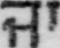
ਜਾ
